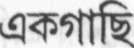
একগাছি
